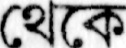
থেকে
